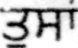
ਤੁਸਾਂ
